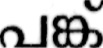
പങ്ക്
